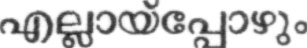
എല്ലായ്പ്പോഴും
